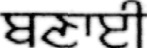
ਬਣਾਈ
